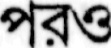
পরও
